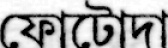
ফোটোদা
